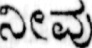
ನೀವು
